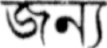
জন্য
